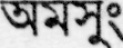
অমসুং
